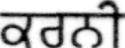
ਕਰਨੀ
